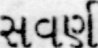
સવર્ણ
